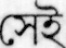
সেই
